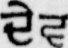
ਦੇਵ
